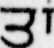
ਤਾਂ
